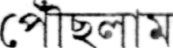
পৌঁছলাম
